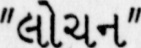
લોચન
